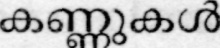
കണ്ണുകള്‍
